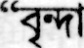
“বৃন্দা
